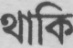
থাকি
